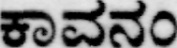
ಕಾವನ೦
